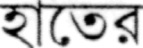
হাতের
